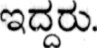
ಇದ್ದರು.
